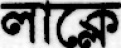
লাক্লে
